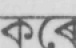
কৰে
